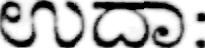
ಉದಾ:
